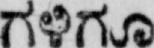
ಗಳಿಗೂ
